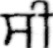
ਸੀ
